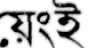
য়েংই
